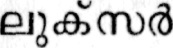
ലുക്സര്‍
